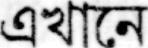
এখানে
